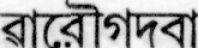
ৱারৌগদবা
